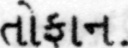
તોફાન.
